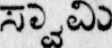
ಸ್ವಾಮಿ
